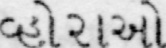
વ્હોરાઓ
